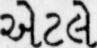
એટલે
